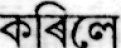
কৰিলে
